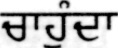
ਚਾਹੁੰਦਾ
